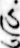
હું
